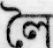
লৈ
